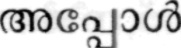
അപ്പോള്‍
